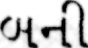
બની
